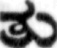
ತು
